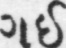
ગઈ
